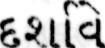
દર્શાવે
